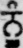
ਨੂੰ
